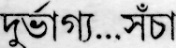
দুর্ভাগ্য..সঁচা
